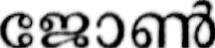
ജോണ്‍
